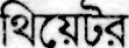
থিয়েটর
